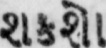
શકશો
